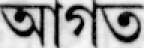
আগত
